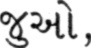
જુઓ,
